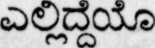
ಎಲ್ಲಿದ್ದೆಯೊ
